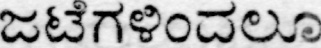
ಜಟೆಗಳಿಂದಲೂ
